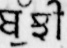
ਬੁੱਝੀ
